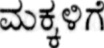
ಮಕ್ಕಳಿಗೆ
